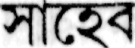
সাহেব
